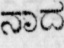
ನಾದ
